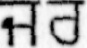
ਜਰ
